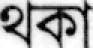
থকা
